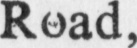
Road,
